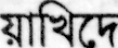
য়াখিদে
